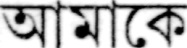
আমাকে
